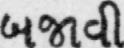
બજાવી
